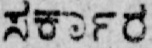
ಸರ್ಕಾರ
